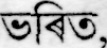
ভৰিত,
